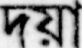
দয়া
